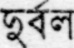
দুর্বল
